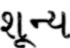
શૂન્ય
